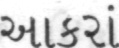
આકરાં
